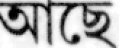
আছে
